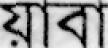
য়াবা
